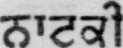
ਨਾਟਕੀ
